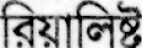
রিয়ালিষ্ট
